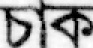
চাক
